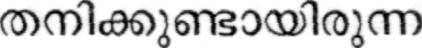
തനിക്കുണ്ടായിരുന്ന
